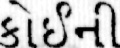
કોઈની
